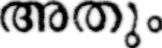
അതും
